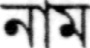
নাম
